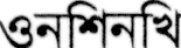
ওনশিনখি
